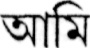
আমি
